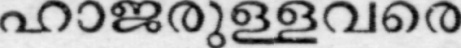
ഹാജരുള്ളവരെ
